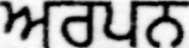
ਅਰਪਨ
